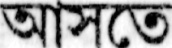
আসতে
